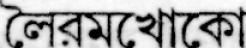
লৈরমখোকো
